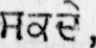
ਸਕਦੇ,
